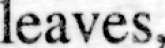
leaves,
